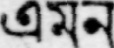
এমন
